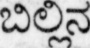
ಬಿಲ್ಲಿನ
